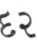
દર
